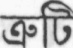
ত্রুটি
